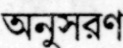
অনুসরণ
